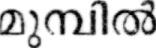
മുമ്പില്‍
